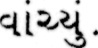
વાંચ્યું.
